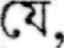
যে,
